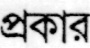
প্রকার
